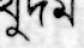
খুদম
